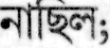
নাছিল;
